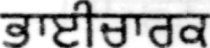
ਭਾਈਚਾਰਕ
